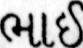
ભાઈ
